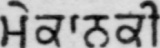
ਮੇਕਾਨਕੀ
